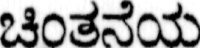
ಚಿಂತನೆಯ
